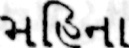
મહિના
